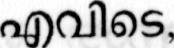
എവിടെ,
